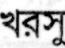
খরসু
